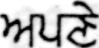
ਅਪਣੇ
